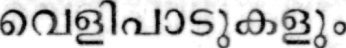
വെളിപാടുകളും
